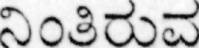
ನಿಂತಿರುವ
